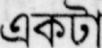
একটা
